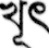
খূৎ
